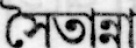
সৈতান্না
